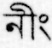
নীং
